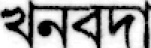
খনবদা
